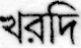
খরদি
